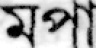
মপা
